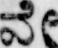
ವೇ
